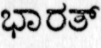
ಭಾರತ್
